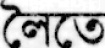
লৈতে
